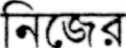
নিজের
